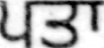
ਪਤਾ
